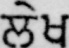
ਲੇਖ
